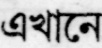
এখানে
